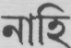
নাহি
